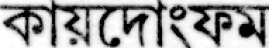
কায়দোংফম
